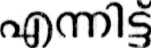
എന്നിട്ട്
